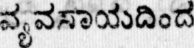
ವ್ಯವಸಾಯದಿಂದ
